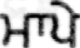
ਮਾਪੇ
